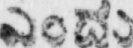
ಎಂದು
